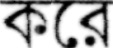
করে
